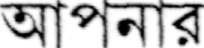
আপনার
